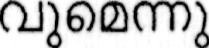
വുമെന്നു
